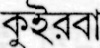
কুইরবা
